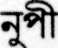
নুপী
